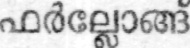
ഫര്‍ല്ലോങ്ങ്
